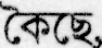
কৈছে,
